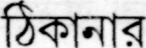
ঠিকানার
